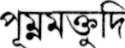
পূম্নমক্তুদি
